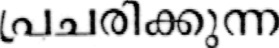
പ്രചരിക്കുന്ന
